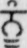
ਨੂੰ
